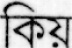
কিয়
